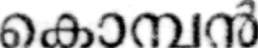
കൊമ്പന്‍
